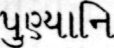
પુણ્યાનિ
